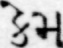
કેમ
